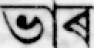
ভাৰ
